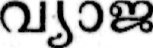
വ്യാജ
